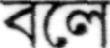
বলে
